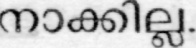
നാക്കില്ല.
